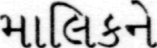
માલિકને
